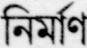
নির্মাণ
